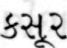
કસૂર
